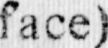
face)
